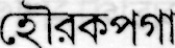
হৌরকপগা
